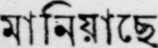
মানিয়াছে
